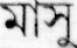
মাসু
